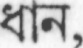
ধান,
